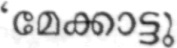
“മേക്കാട്ടു
